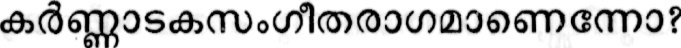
കര്‍ണ്ണാടകസംഗീതരാഗമാണെന്നോ?
